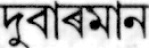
দুবাৰমান
